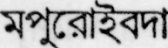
মপুরোইবদা
